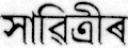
সাৱিত্রীৰ
